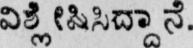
ವಿಶ್ಲೇಷಿಸಿದ್ದಾನೆ.
